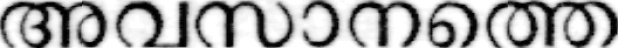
അവസാനത്തെ
